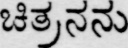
ಚಿತ್ರನನು
